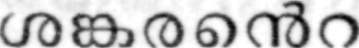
ശങ്കരന്റെ
